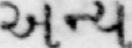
અન્ય
